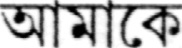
আমাকে
